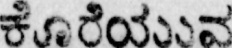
ಕೊರೆಯುವ
